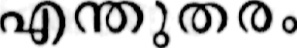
എന്തുതരം
